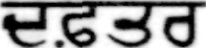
ਦਫ਼ਤਰ
